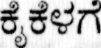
ಕೈಕೆಳಗೆ
